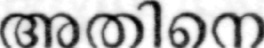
അതിനെ
